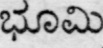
ಭೂಮಿ
